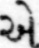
એ
